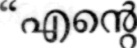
“എന്റെ
